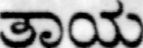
ತಾಯ
